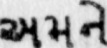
અમને
